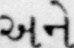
અને
